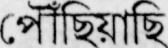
পৌঁছিয়াছি
